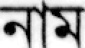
নাম
